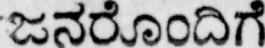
ಜನರೊಂದಿಗೆ
